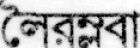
লৈরম্লবা
